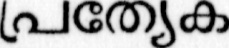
പ്രത്യേക
